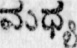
ಮಧ್ಯ
